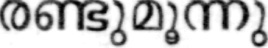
രണ്ടുമൂന്നു
